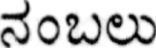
ನಂಬಲು
